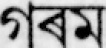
গৰম
